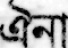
ঐনা
